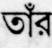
তাঁর
